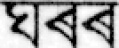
ঘৰৰ
